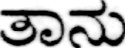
ತಾನು
